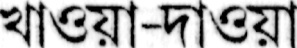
খাওয়া-দাওয়া
